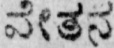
ವೇತನ
